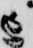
હું
